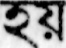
হয়
